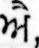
ਐ,
